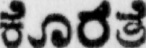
ಕೊರತೆ
